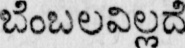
ಬೆಂಬಲವಿಲ್ಲದೆ
